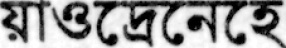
য়াওদ্রেনেহে
